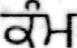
ਕੰਮ
